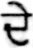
ਦੇ
